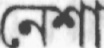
নেশা
